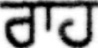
ਰਾਹ
